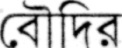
বৌদির
